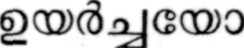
ഉയര്‍ച്ചയോ
